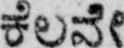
ಕೆಲವೇ
